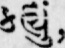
કહ્યું,
